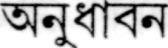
অনুধাবন
